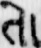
તો
